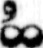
ಹಿ
